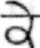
ਕੇ
